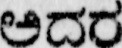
ಅದರ
